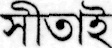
সীতাই
